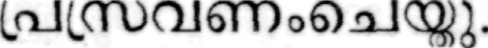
പ്രസ്രവണംചെയ്തു.
